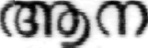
ആന
